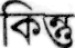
কিন্তু
